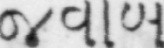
જવાબ
